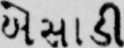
બેસાડી
